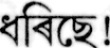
ধৰিছে!
